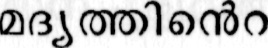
മദ്യത്തിന്റെ
